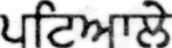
ਪਟਿਆਲੇ
